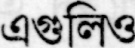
এগুলিও
